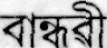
বান্ধৱী
